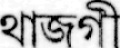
থাজগী
